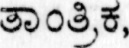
ತಾಂತ್ರಿಕ,
